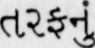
તરફનું
